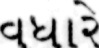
વધારે
